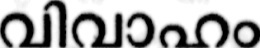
വിവാഹം
